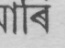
মাৰি
